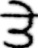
ਤੇ
